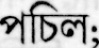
পচিল;
